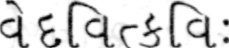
વેદવિત્કવિઃ
